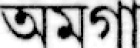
অমগা
